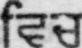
ਵਿਚ
